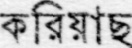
করিয়াছ
